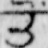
ਤੋਂ
